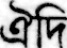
ঐদি
